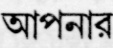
আপনার
